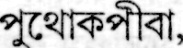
পুথোকপীবা,
